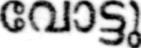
വോട്ടു
